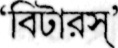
‘বিটারস্’
